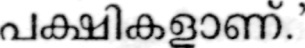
പക്ഷികളാണ്.’
